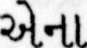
એના
